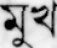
মুখ
